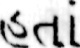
હતાં
